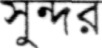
সুন্দর
